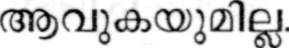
ആവുകയുമില്ല.
